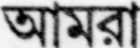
আমরা
